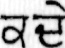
ਕਦੇ
